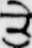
ਤੇ
